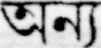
অন্য
